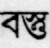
বস্তু
